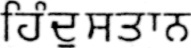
ਹਿੰਦੁਸਤਾਨ
